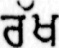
ਰੱਖ
